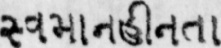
સ્વમાનહીનતા
